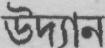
উদ্যান
